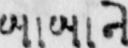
બાબાને
